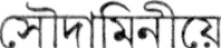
সৌদামিনীয়ে
